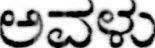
ಅವಳು
